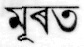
মুৰত
